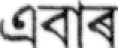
এবাৰ
